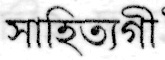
সাহিত্যগী
